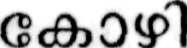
കോഴി
